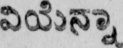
ವಿಯೆನ್ನಾ
